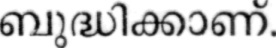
ബുദ്ധിക്കാണ്.
